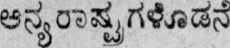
ಅನ್ಯರಾಷ್ಟ್ರಗಳೊಡನೆ
